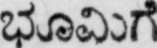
ಭೂಮಿಗೆ
